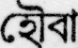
হৌবা
